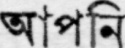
আপনি
